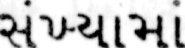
સંખ્યામાં
